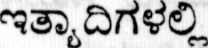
ಇತ್ಯಾದಿಗಳಲ್ಲಿ
